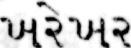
ખરેખર
